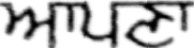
ਆਪਣਾ
